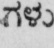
ಗಳು
